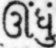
ઊંધુ
